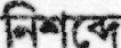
নিশব্দে
